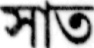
সাত
